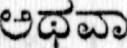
ಅಥವಾ
